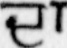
ਦਾ
